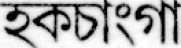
হকচাংগা
